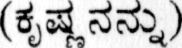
(ಕೃಷ್ಣನನ್ನು)
